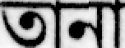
তানা
